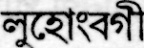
লুহোংবগী
